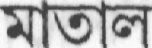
মাতাল
